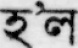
হ'ল
